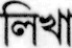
লিখা
